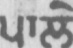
ਪਾਲੇ
